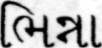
ભિન્ના
